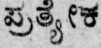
ಪ್ರತ್ಯೇಕ
